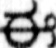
ಈ
